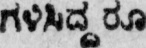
ಗಳಿಸಿದ್ದರೂ
